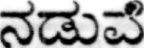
ನಡುವೆ
